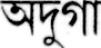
অদুগা
